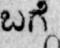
ಬಗ್ಗೆ
